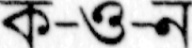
ক-ও-ন
